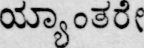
ಯ್ಯಾಂತರೇ
